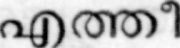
എത്തീ
